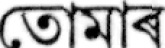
তোমাৰ
